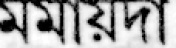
মমায়দা
